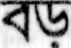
বড়
